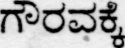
ಗೌರವಕ್ಕೆ
